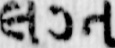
લગ્ન
